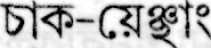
চাক-য়েঞ্ছাং
